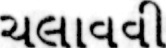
ચલાવવી
